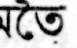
মতৈ
